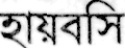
হায়বসি
